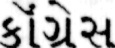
કૉંગ્રેસ
